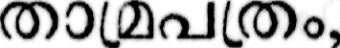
താമ്രപത്രം,
